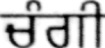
ਚੰਗੀ
